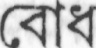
বোধ
